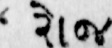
'રોજ
